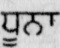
ਧੂਨਾ
